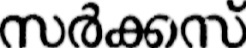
സര്‍ക്കസ്
